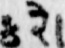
કરો
